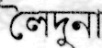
লৈদুনা
